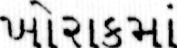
ખોરાકમાં
